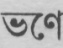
ভণে
